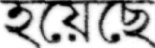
হয়েছে
